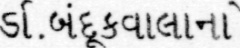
ર્ડા.બંદૂકવાલાનો
